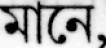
মানে,
